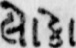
લોકો
